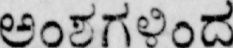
ಅಂಶಗಳಿಂದ
